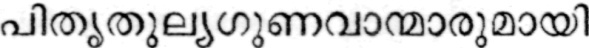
പിതൃതുല്യഗുണവാന്മാരുമായി
